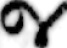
જ
